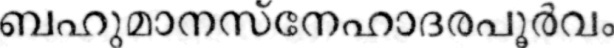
ബഹുമാനസ്നേഹാദരപൂര്‍വം
